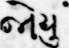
જોયું
